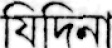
যিদিনা
